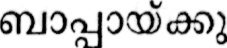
ബാപ്പായ്ക്കു
